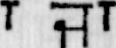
ਜਾ
